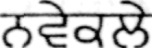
ਨਵੇਕਲੇ
